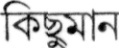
কিছুমান
